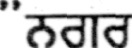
''ਨਗਰ
